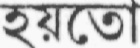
হয়তো
